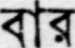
বার
